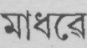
মাধৱে
